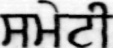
ਸਮੇਟੀ
